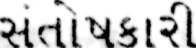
સંતોષકારી
